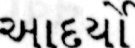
આદર્યો
